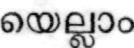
യെല്ലാം
